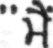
''ਮੈਂ
